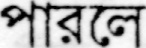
পারলে
